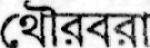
থৌরবরা
